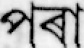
পৰা
